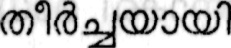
തീര്‍ച്ചയായി
